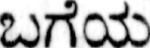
ಬಗೆಯ
